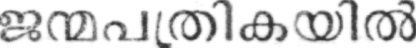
ജന്മപത്രികയില്‍
